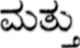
ಮತ್ತು
